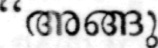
"അങ്ങു
